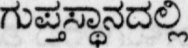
ಗುಪ್ತಸ್ಥಾನದಲ್ಲಿ
